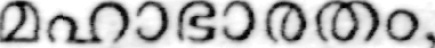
മഹാഭാരതം,
